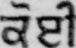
ਕੋਈ
